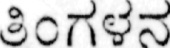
ತಿಂಗಳನ
